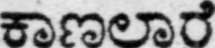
ಕಾಣಲಾರೆ
